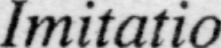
Imitatio
